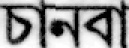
চানবা
